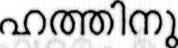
ഹത്തിനു
